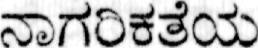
ನಾಗರಿಕತೆಯ
